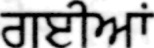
ਗਈਆਂ
